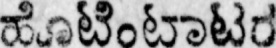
ಹೊಟೆಂಟಾಟರ
